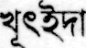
খূৎইদা
